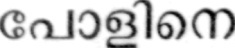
പോളിനെ
